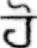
ਹੋ
